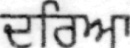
ਦਰਿਆ
